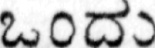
ಒಂದು
